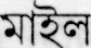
মাইল
